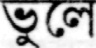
ভুলে
